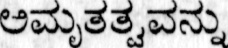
ಅಮೃತತ್ವವನ್ನು
